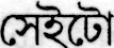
সেইটো
